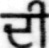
ਦੀ
